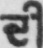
ਦੀ
